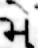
મેં
